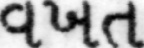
વખત
